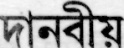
দানবীয়
